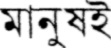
মানুষই
